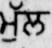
ਮੁੱਲ
